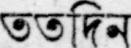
ততদিন
